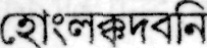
হোংলক্কদবনি
